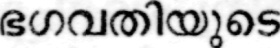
ഭഗവതിയുടെ
